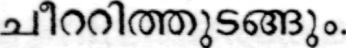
ചീററിത്തുടങ്ങും.
